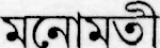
মনোমতী
